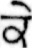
ਕੇ
